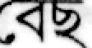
বেছ
